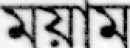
ময়াম
